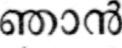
ഞാന്‍
